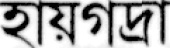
হায়গদ্রা
